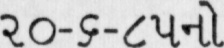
૨૦-૬-૮૫નો
